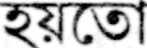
হয়তো
